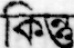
কিন্তু
